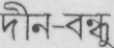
দীন-বন্ধু
